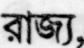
রাজ্য,
